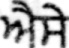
ਐਸੇ
